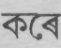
কৰে
